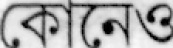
কোনেও
